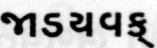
જાડયવક્
